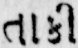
તાકી
